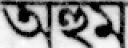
অহুম
